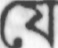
যে
